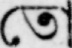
তো
